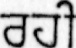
ਰਹੀ
